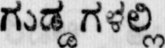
ಗುಡ್ಡಗಳಲ್ಲಿ
